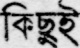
কিছুই
